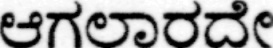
ಆಗಲಾರದೇ
